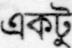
একটু
